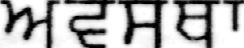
ਅਵਸਥਾ
